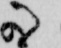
જે
